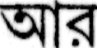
আর
